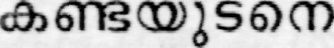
കണ്ടയുടനെ
